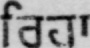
ਰਿਹਾ
